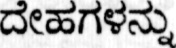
ದೇಹಗಳನ್ನು
